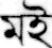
মই
